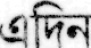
এদিন
